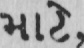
માટે,
